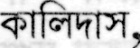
কালিদাস,
